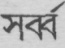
সৰ্ব্ব
